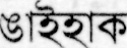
ঙাইহাক
